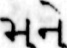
મને
